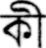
কী
